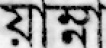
য়াম্না
